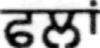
ਫਲਾਂ
